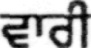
ਵਾਰੀ
